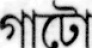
গাটো
